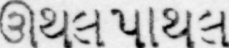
ઊથલપાથલ
